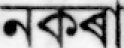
নকৰা
